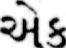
એક
